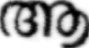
ആ
